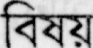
বিষয়
